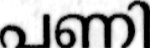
പണി
